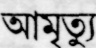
আমৃত্যু
